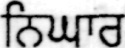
ਨਿਘਾਰ
